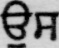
ਉਸ
